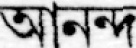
আনন্দ
